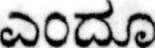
ಎಂದೂ
